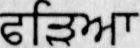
ਫੜਿਆ
